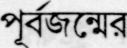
পূর্বজন্মের
